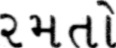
રમતો
